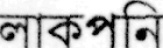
লাকপনি
